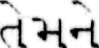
તેમને
